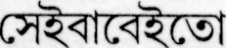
সেইবাবেইতো
